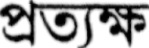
প্রত্যক্ষ
